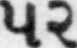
પર
